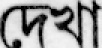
দেখা
